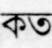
কত
